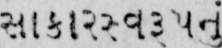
સાકારસ્વરૂપનું
